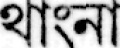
থাংনা
